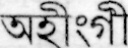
অহীংগী
